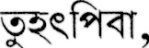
তুহৎপিবা,
